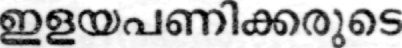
ഇളയപണിക്കരുടെ
